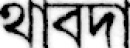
থাবদা
